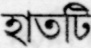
হাতটি
